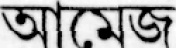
আমেজ
